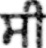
ਸੀ
